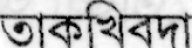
তাকখিবদা
